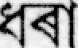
ধৰা
